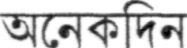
অনেকদিন
